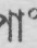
পা
